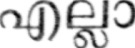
എല്ലാ
